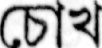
চোখ
